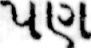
પણ
